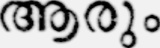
ആരും
